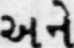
અને
